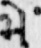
મેં
